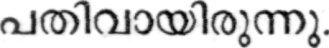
പതിവായിരുന്നു.
